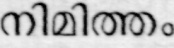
നിമിത്തം
